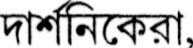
দার্শনিকেরা,
